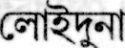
লোইদুনা
